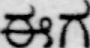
ಈಗ
